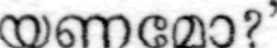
യണമോ?’
